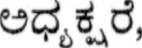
ಅಧ್ಯಕ್ಷರೆ,
